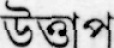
উত্তাপ
